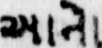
આનો
